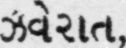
ઝવેરાત,
